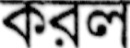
করল
